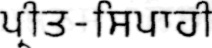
ਪ੍ਰੀਤ-ਸਿਪਾਹੀ
